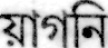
য়াগনি
